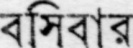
বসিবার
